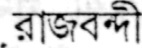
রাজবন্দী
